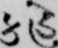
કહે
